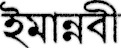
ইমান্নবী
